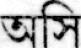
অসি
